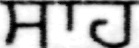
ਸਾਹ
